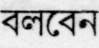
বলবেন
